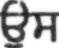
ਉਸ
